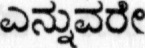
ಎನ್ನುವರೇ
